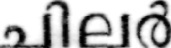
ചിലര്‍
